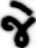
જે
